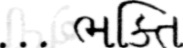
...ભક્તિ
